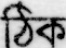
ঠিক
